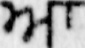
ਆ
